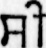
ਸੀ
